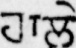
ਹਾਲੇ
